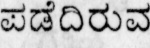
ಪಡೆದಿರುವ
